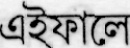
এইফালে
